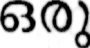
ഒരു
